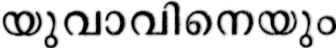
യുവാവിനെയും
